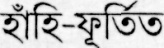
হাঁহি-ফূর্তিত
